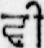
ਵੀ
